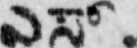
ಎಸ್.
